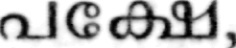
പക്ഷേ,
